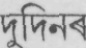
দুদিনৰ
